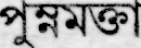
পুম্নমক্তা
